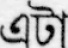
এটা
